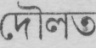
দৌলত
